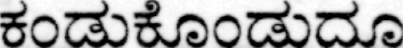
ಕಂಡುಕೊಂಡುದೂ
